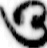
ও
